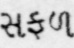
સફળ
